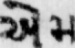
એમ
